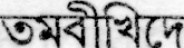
তমবীখিদে
